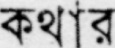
কথার
